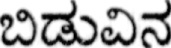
ಬಿಡುವಿನ
